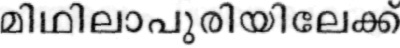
മിഥിലാപുരിയിലേക്ക്
